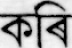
কৰি
